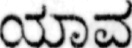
ಯಾವ
